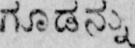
ಗೂಡನ್ನು
